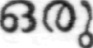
ഒരു
